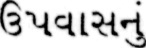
ઉપવાસનું
